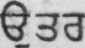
ਉਤਰ
